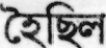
হৈছিল
